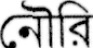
নৌরি
